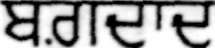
ਬਗ਼ਦਾਦ
